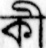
কী
